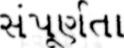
સંપૂર્ણતા
